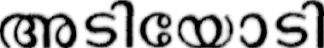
അടിയോടി
